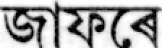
জাফৰে
